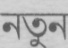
নতুন
